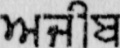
ਅਜੀਬ
